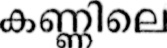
കണ്ണിലെ
